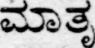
ಮಾತೃ
